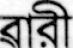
ৱারী
